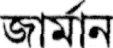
জার্মান
